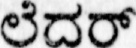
ಲೆದರ್
